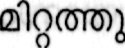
മിറ്റത്തു
